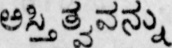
ಅಸ್ತಿತ್ವವನ್ನು
